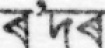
ৰ'দৰ
